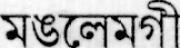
মঙলেমগী
